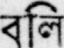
বলি
